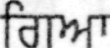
ਗਿਆ
